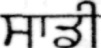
ਸਾਡੀ
